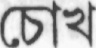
চোখ
